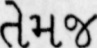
તેમજ
